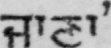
ਜਾਣਾ'
